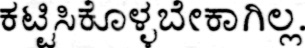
ಕಟ್ಟಿಸಿಕೊಳ್ಳಬೇಕಾಗಿಲ್ಲ.
